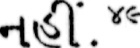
નહીં.૪૯
